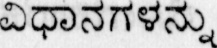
ವಿಧಾನಗಳನ್ನು
